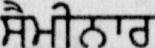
ਸੈਮੀਨਾਰ
